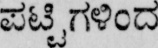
ಪಟ್ಟಿಗಳಿಂದ
